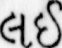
લઈ
